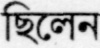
ছিলেন
